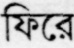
ফিরে
